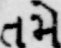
તમે
